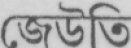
জেউতি
